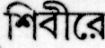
শিবীরে
